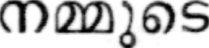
നമ്മുടെ
